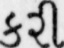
કરી
